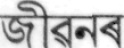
জীৱনৰ
